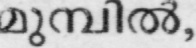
മുമ്പില്‍,
